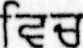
ਵਿਚ
